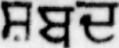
ਸ਼ਬਦ
